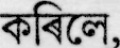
কৰিলে,
